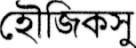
হৌজিকসু
